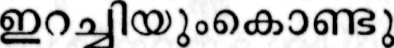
ഇറച്ചിയുംകൊണ്ടു
